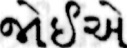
જોઈએ
